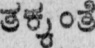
ತಕ್ಕಂತೆ
